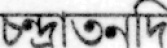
চন্দ্রাতনদি
